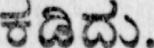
ಕಡಿದು.
